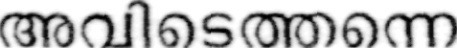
അവിടെത്തന്നെ
